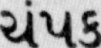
ચંપક
